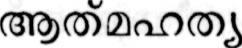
ആത്മഹത്യ
